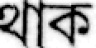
থাক
